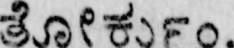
ತೋರ್ಕುಂ.
